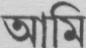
আমি
